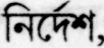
নির্দেশ,
